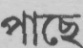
পাছে
